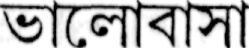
ভালোবাসা
